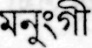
মনুংগী
